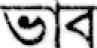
ভাব
